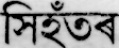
সিহঁতৰ
